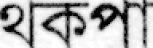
থকপা
